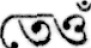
তেওঁ
